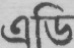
এড়ি
